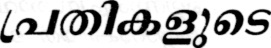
പ്രതികളുടെ
